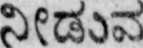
ನೀಡುವ
